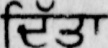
ਦਿੱਤਾ
